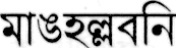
মাঙহল্লবনি
